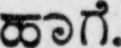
ಹಾಗೆ.
